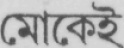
মোকেই
